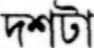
দশটা
